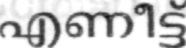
എണീട്ട്
